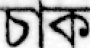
চাক
